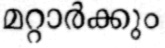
മറ്റാര്‍ക്കും
